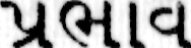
પ્રભાવ
